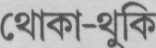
থোকা-থুকি
